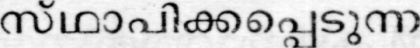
സ്ഥാപിക്കപ്പെടുന്ന
